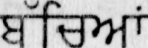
ਬੱਚਿਆਂ
